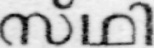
സ്ഥി
